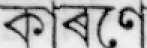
কাৰণে
